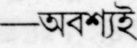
–অবশ্যই
